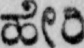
ಹೇರಿ
